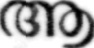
ആ
